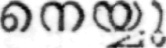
നെയ്യു
